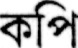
কপি
